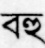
বহু
